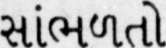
સાંભળતો
